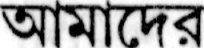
আমাদের
